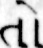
તો
